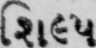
શિલ્પ
